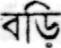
বড়ি
